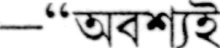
–“অবশ্যই
